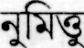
নুমিত্তু
